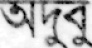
অদুবু
